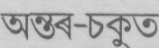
অন্তৰ-চকুত
